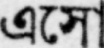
এসো
